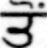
ਤੋਂ
